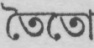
তৈতো
